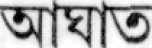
আঘাত
